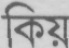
কিয়
